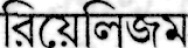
রিয়েলিজম
